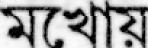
মখোয়
